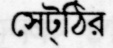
সেট্ঠির
